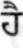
ਹੈ
